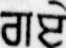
ਗਏ
